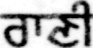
ਰਾਣੀ
